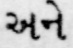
અને
